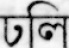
ঢলি
